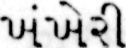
ખંખેરી
